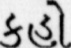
કહો
